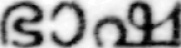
ഭാഷ
